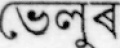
ভেলুৰ
